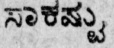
ಸಾಕಷ್ಟು
